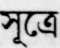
সূত্রে
